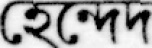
হেন্দেদ
